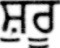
ਸ਼ੁਰੂ
